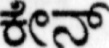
ಕೇನ್
